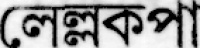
লেল্লকপা
